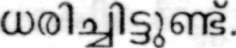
ധരിച്ചിട്ടുണ്ട്.
